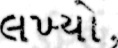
લખ્યો,
